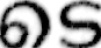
ടെ
